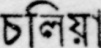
চলিয়া
